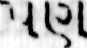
પણ
